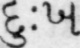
દુઃખ
